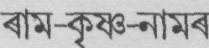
ৰাম-কৃষ্ণ-নামৰ
